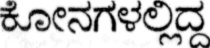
ಕೋನಗಳಲ್ಲಿದ್ದ
